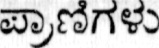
ಪ್ರಾಣಿಗಳು
